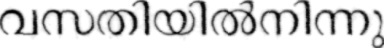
വസതിയില്‍നിന്നു
